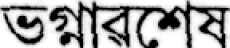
ভগ্নাৱশেষ
